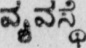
ವ್ಯವಸ್ಥೆ
